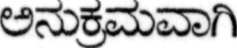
ಅನುಕ್ರಮವಾಗಿ
